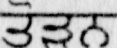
ਤੋੜਨ
